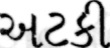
અટકી
